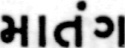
માતંગ
